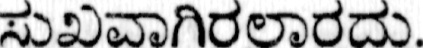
ಸುಖವಾಗಿರಲಾರದು.
